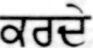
ਕਰਦੇ
